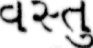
વસ્તું
